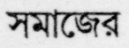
সমাজের
